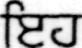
ਇਹ
